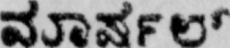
ಮಾರ್ಷಲ್
